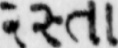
રસ્તા
